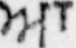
ਆ
